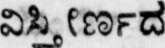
ವಿಸ್ತೀರ್ಣದ
